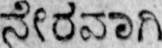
ನೇರವಾಗಿ
